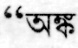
“অঙ্ক
